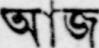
আজ
